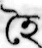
হৈ
